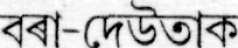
বৰা-দেউতাক
